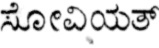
ಸೋವಿಯತ್
